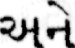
અને
